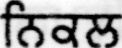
ਨਿਕਲ
